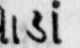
થોડાં
